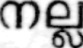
നല്ല
